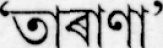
'তাৰাণা'
